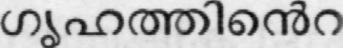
ഗൃഹത്തിന്റെ
